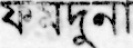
ফমদুনা
